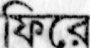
ফিরে
